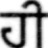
ਹੀ
